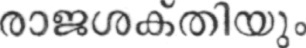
രാജശക്തിയും
